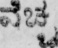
ವೆಚ್ಚ
